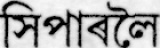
সিপাৰলৈ
